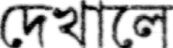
দেখালে
